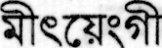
মীৎয়েংগী
